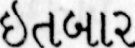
ઇતબાર
